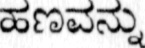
ಹಣವನ್ನು
